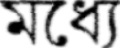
মধ্যে
